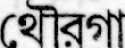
থৌরগা
